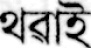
থৱাই
